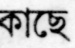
কাছে
